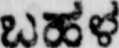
ಬಹಳ
